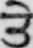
ਤੇ
